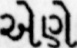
એણે
